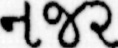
નજર
